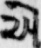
એ
